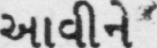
આવીને
